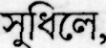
সুধিলে,
